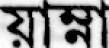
য়াম্না
